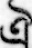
ঐ
